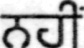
ਨਹੀਂ
